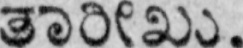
ತಾರೀಖು.
